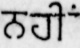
ਨਹੀਂ
